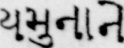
યમુનાને
